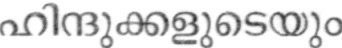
ഹിന്ദുക്കളുടെയും
